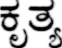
ಕೃತ್ಯ
